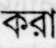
করা
